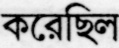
করেছিল
